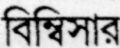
বিম্বিসার
